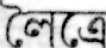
লৈত্রে
